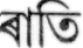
ৰাতি
